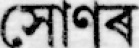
সোণৰ
